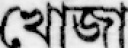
খোজা
